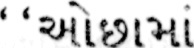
"ઓછામાં
